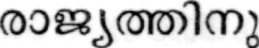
രാജ്യത്തിനു
